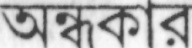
অন্ধকার
